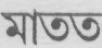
মাতত
